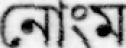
নোংম
